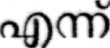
എന്ന്
